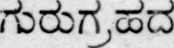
ಗುರುಗ್ರಹದ
